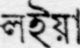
লইয়া
